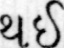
થઈ
